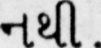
નથી.
